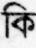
কি
